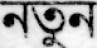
নতুন
